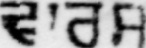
ਵਾਰਸ
